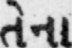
તેના
